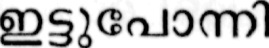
ഇട്ടുപോന്നി
